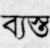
ব্যস্ত
